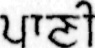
ਪਾਣੀ
